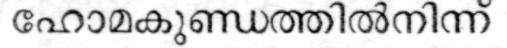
ഹോമകുണ്ഡത്തില്‍നിന്ന്
